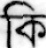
কি
